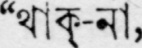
‘‘থাক্‌-না,
